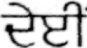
ਦੇਈਂ
